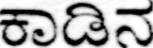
ಕಾಡಿನ
